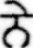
ਨੇ
